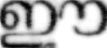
ഈ
